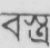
বস্ত্র
